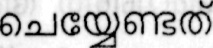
ചെയ്യേണ്ടത്
